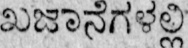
ಖಜಾನೆಗಳಲ್ಲಿ
